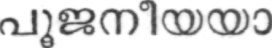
പൂജനീയയാ
